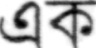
এক
